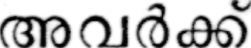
അവര്‍ക്ക്
